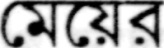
মেয়ের
